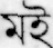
মই
